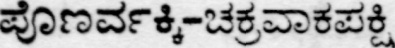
ಪೊಣರ್ವಕ್ಕಿ-ಚಕ್ರವಾಕಪಕ್ಷಿ
